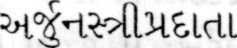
અર્જુનસ્ત્રીપ્રદાતા
